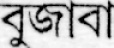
বুজাবা
